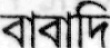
বাবাদি
